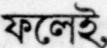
ফলেই,
